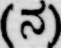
(ನ)
